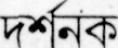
দর্শনক
